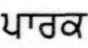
ਪਾਰਕ
